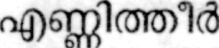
എണ്ണിത്തീര്‍
